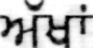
ਅੱਖਾਂ
